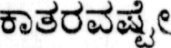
ಕಾತರವಷ್ಟೇ
